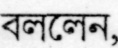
বললেন,
